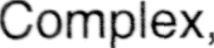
Complex,
